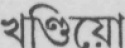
খণ্ডিয়ো
